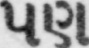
પણ
